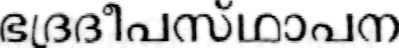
ഭദ്രദീപസ്ഥാപന
